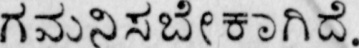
ಗಮನಿಸಬೇಕಾಗಿದೆ.
